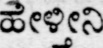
ಹೇಳ್ತೀನಿ
